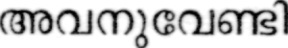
അവനുവേണ്ടി
